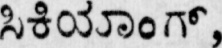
ಸಿಕಿಯಾಂಗ್,
